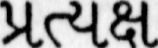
પ્રત્યક્ષ
